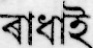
ৰাধাই
